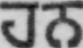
ਹਨ
